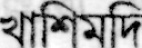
খাশিমদি
